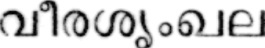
വീരശൃംഖല
